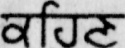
ਕਹਿਣ
